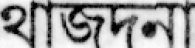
থাজদনা
